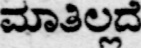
ಮಾತಿಲ್ಲದೆ
